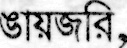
ঙায়জরি,
